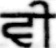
ਵੀ
